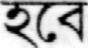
হবে
